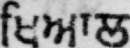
ਖਿਆਲ
